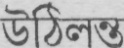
উঠিলন্ত
